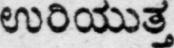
ಉರಿಯುತ್ತ
